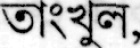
তাংখুল,
